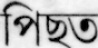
পিছত
